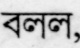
বলল,
